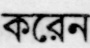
করেন
